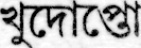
খুদোপ্তো
